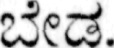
ಬೇಡ.
